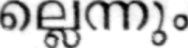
ല്ലെന്നും
